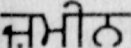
ਜ਼ਮੀਨ
